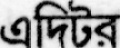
এদিটর
